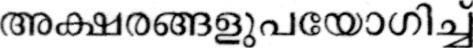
അക്ഷരങ്ങളുപയോഗിച്ച്
